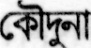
কৌদুনা
